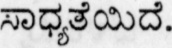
ಸಾಧ್ಯತೆಯಿದೆ.
